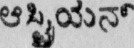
ಆಸ್ಟ್ರಿಯನ್
